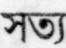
সত্য
